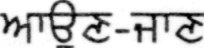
ਆਉਣ-ਜਾਣ
